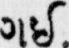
ગઈ.
